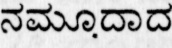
ನಮೂದಾದ
